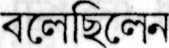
বলেছিলেন
